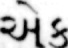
એક
